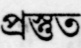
প্রস্তুত
